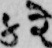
કરે
